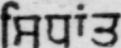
ਸਿਧਾਂਤ
